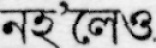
নহ'লেও
